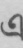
এ
